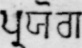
ਪ੍ਰਯੋਗ
